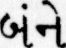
બંને
